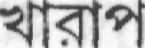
খারাপ
